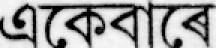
একেবাৰে
